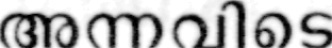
അന്നവിടെ
